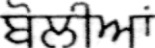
ਬੋਲੀਆਂ
